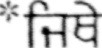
*ਜਿਥੇ
